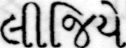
લીજિયે
